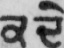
ਕਦੇ
